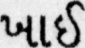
ખાઈ
